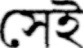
সেই
